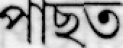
পাছত
